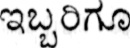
ಇಬ್ಬರಿಗೂ
